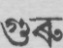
গুৰু
